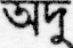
অদু
